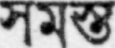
সমস্ত
